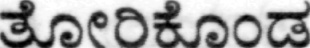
ತೋರಿಕೊಂಡ
